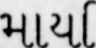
માર્યા
